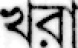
খরা
